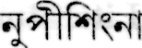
নুপীশিংনা
